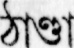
ঠাণ্ডা
